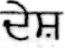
ਦੇਸ਼
